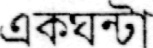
একঘন্টা
